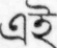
এই
